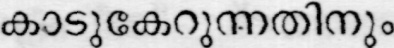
കാടുകേറുന്നതിനും
